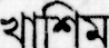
খাশিম
